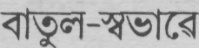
বাতুল-স্বভাৱে
